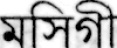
মসিগী
